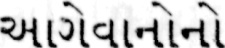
આગેવાનોનો
